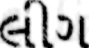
લીગ
